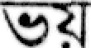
ভয়
